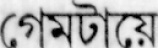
গেমটায়ে
